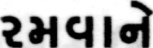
રમવાને
